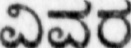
ವಿವರ
